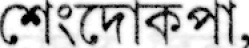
শেংদোকপা,
